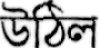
উঠিল
